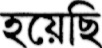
হয়েছি
